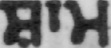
ਸ਼ਾਮ
